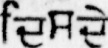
ਦਿਸਦੇ
